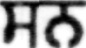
ਸਨ
